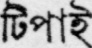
টিপাই
